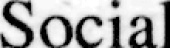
Social
